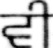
ਵੀ
